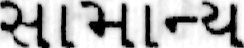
સામાન્ય
